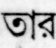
তার
